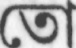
তো
